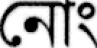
নোং
